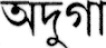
অদুগা
